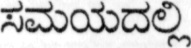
ಸಮಯದಲ್ಲಿ
